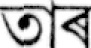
তাৰ
